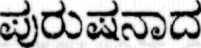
ಪುರುಷನಾದ
